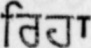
ਰਿਹਾ
